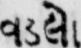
વડલો
